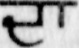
ਦਾ
